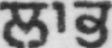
ਲਾਭ
